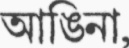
আঙিনা,
